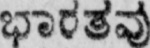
ಭಾರತವು
